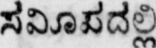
ಸಮೀಪದಲ್ಲಿ
